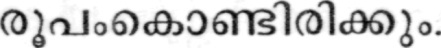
രൂപംകൊണ്ടിരിക്കും.
